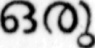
ഒരു
